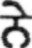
ਨੇ
